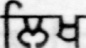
ਲਿਖ
